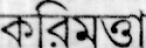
করিমত্তা
